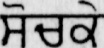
ਸੋਚਕੇ
